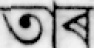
তাৰ
